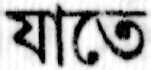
যাতে
